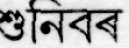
শুনিবৰ
